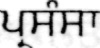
ਪ੍ਰਸੰਸਾ
